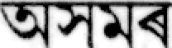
অসমৰ
